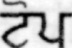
ਟੋਪ
